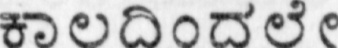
ಕಾಲದಿಂದಲೇ
